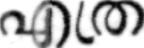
എത്ര
